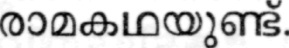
രാമകഥയുണ്ട്.
